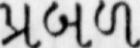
પ્રબળ
